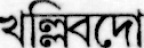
খল্লিবদো
